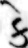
કે
